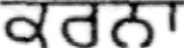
ਕਰਨਾ
